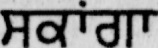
ਸਕਾਂਗਾ
